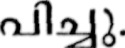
പിച്ചു.
